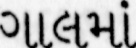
ગાલમાં
